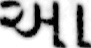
આ
